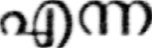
എന്ന
